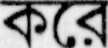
করে
